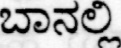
ಬಾನಲ್ಲಿ
